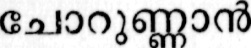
ചോറുണ്ണാന്‍
